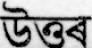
উত্তৰ
